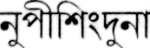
নুপীশিংদুনা
